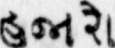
હજારો
